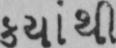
ક્યાંથી
